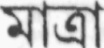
মাত্রা
